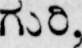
ಗುರಿ,
